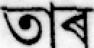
তাৰ
